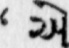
'એ
